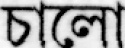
চালো
